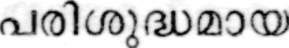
പരിശുദ്ധമായ
